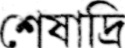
শেষাদ্রি
